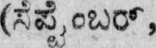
(ಸೆಪ್ಟೆಂಬರ್,
